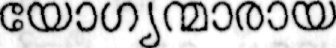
യോഗ്യന്മാരായ
